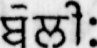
ਬੋਲੀ:
